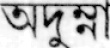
অদুম্না
